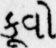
કૂવો
